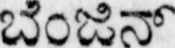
ಬೆ೦ಜಿನ್
